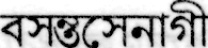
বসন্তসেনাগী
